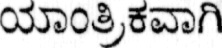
ಯಾಂತ್ರಿಕವಾಗಿ
